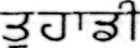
ਤੁਹਾਡੀ
